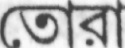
তোরা
